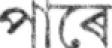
পাৰে
